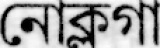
নোক্লগা
